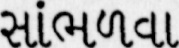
સાંભળવા
